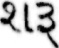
શરૂ
